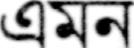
এমন
